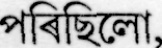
পৰিছিলো,
